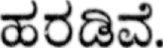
ಹರಡಿವೆ.
